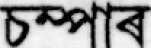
চম্পাৰ
